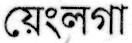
য়েংলগা
